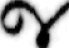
જ
